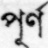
পূর্ণ
